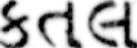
કતલ
